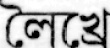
লৈখ্রে
